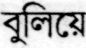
বুলিয়ে
